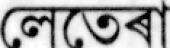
লেতেৰা
